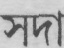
সদা
